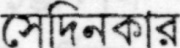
সেদিনকার
